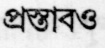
প্রস্তাবও
